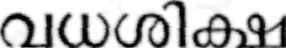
വധശിക്ഷ
